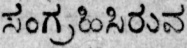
ಸಂಗ್ರಹಿಸಿರುವ
